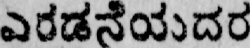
ಎರಡನೆಯದರ
